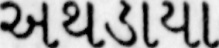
અથડાયા
